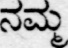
ನಮ್ಮ
